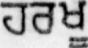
ਹਰਖੂ
